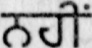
ਨਹੀਂ
